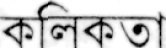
কলিকতা
